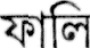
ফালি
